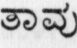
ತಾವು
